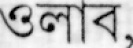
ওলাব,
